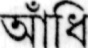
আঁধি
